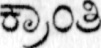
ಕ್ರಾಂತಿ
